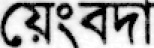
য়েংবদা
